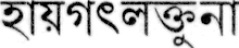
হায়গৎলক্তুনা
